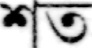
শত
